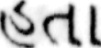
હતા
